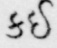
કઈ
